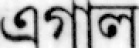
এগাল
